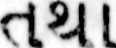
તથા
